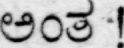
ಅಂತ!
